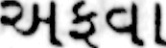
અફવા
